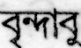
বৃন্দাবু
